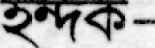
হন্দক-
